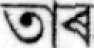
তাৰ
